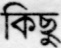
কিছু
